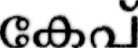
കേപ്
